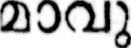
മാവു
